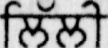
ਲਿੱਲੀ
